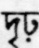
দৃঢ়
